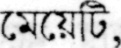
মেয়েটি,
